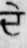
ਦੇ
